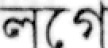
লগে
